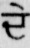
ਦੇ
